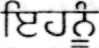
ਇਹਨੂੰ
